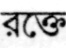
রক্তে
